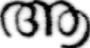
ആ
